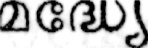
മദ്ധ്യേ
